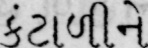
કંટાળીને
